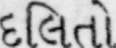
દલિતો
